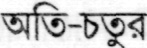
অতি-চতুর
